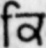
ਕਿ
